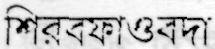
শিরবফাওবদা
